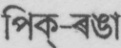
পিক্‌-ৰঙা
